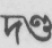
দণ্ড
